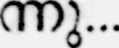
ന്നു...
